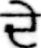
ਦੇ
